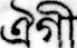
ঐগী
